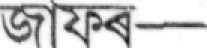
জাফৰ-
